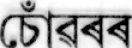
চোঁৱৰৰ
